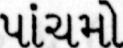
પાંચમો
